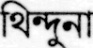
থিন্দুনা
